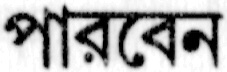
পারবেন
